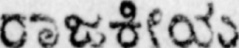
ರಾಜಕೀಯ
